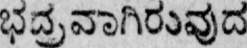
ಭದ್ರವಾಗಿರುವುದ
